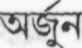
অর্জুন
